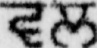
ਵਲ
